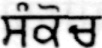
ਸੰਕੋਚ
